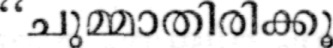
"ചുമ്മാതിരിക്കൂ
